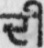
ਦੀ
